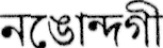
নঙোন্দগী
